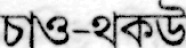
চাও-থকউ
